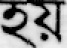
হয়
